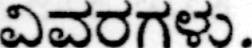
ವಿವರಗಳು.
